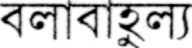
বলাবাহুল্য
